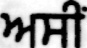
ਅਸੀਂ
